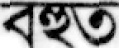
বহুত
